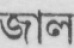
জাল
